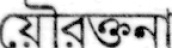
য়ৌরক্তনা
